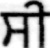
ਸੀ
